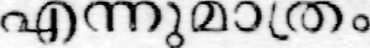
എന്നുമാത്രം
